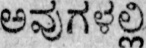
ಅವುಗಳಲ್ಲಿ
